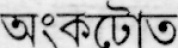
অংকটোত
